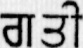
ਗਤੀ
